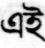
এই
